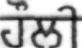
ਹੌਲੀ
